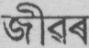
জীৱৰ
